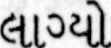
લાગ્યો
